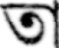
তা
